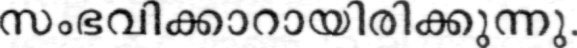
സംഭവിക്കാറായിരിക്കുന്നു.
